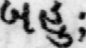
બહુ;
